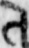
તે
